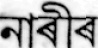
নাৰীৰ
